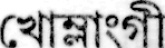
খোম্লাংগী
